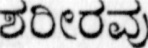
ಶರೀರವು
